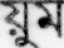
য়ুম
